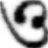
ও
